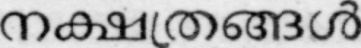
നക്ഷത്രങ്ങള്‍
